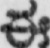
ಈ
